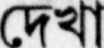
দেখা
